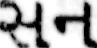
સન
